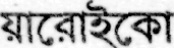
য়ারোইকো
